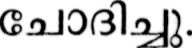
ചോദിച്ചു.
